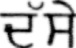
ਦੱਸੇ
